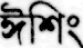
ঈশিং
